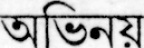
অভিনয়
